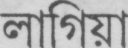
লাগিয়া
